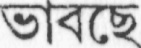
ভাবছে
